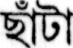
ছাঁটা
